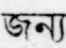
জন্য
